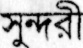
সুন্দরী
